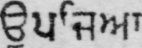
ਉਪਜਿਆ
